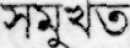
সমুখত
